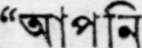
‘‘আপনি
